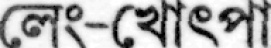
লেৎ-খোৎপা
